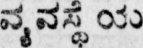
ವ್ಯವಸ್ಥೆಯ
